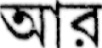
আর
